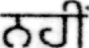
ਨਹੀਂ
